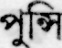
পুন্সি
